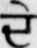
ਦੇ
